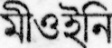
মীওইনি
